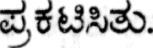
ಪ್ರಕಟಿಸಿತು.
